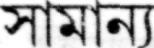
সামান্য
